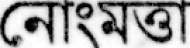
নোংমত্তা
